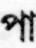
পা
